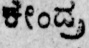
ಕೇಂದ್ರ
